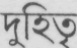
দুহিতৃ
